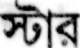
স্টার
